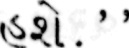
હશે."
